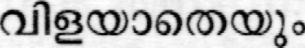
വിളയാതെയും
